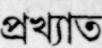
প্রখ্যাত
